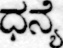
ಧನ್ಯೆ
